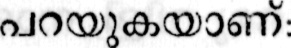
പറയുകയാണ്:
